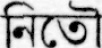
নিতৌ
